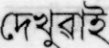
দেখুৱাই
